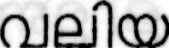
വലിയ
